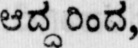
ಆದ್ದರಿಂದ,
